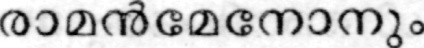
രാമന്‍മേനോനും
